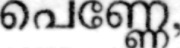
പെണ്ണേ,
